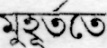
মুহূর্ততে
